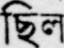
ছিল
